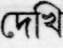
দেখি
